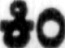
ಕಿಂ
